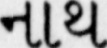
નાથ
